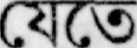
যেতে
